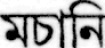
মচানি
